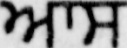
ਆਸ
